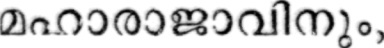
മഹാരാജാവിനും,
